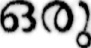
ഒരു
